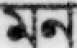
মন
